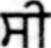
ਸੀ
